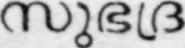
സുഭദ്ര
